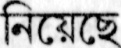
নিয়েছে
